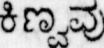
ಕಿಣ್ವವು
